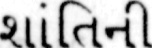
શાંતિની
